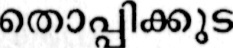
തൊപ്പിക്കുട
